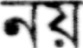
নয়
